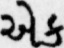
એક
